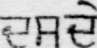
ਦਸਦੇ
